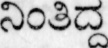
ನಿಂತಿದ್ದ
